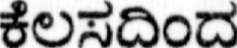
ಕೆಲಸದಿಂದ
